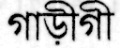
গাড়ীগী
